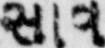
સાવ
